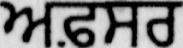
ਅਫ਼ਸਰ
